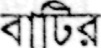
বাটির
